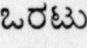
ಒರಟು
